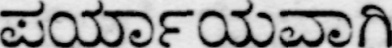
ಪರ್ಯಾಯವಾಗಿ
